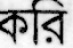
করি
